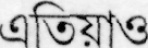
এতিয়াও
